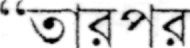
“তারপর
